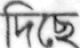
দিছে
